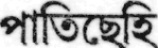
পাতিছেহি
